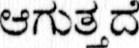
ಆಗುತ್ತದೆ
